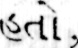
હતો,
